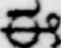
ಈ
